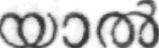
യാല്‍
